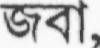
জবা,
